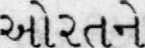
ઓરતને
